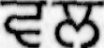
ਵਲ
